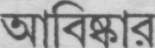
আবিষ্কার
